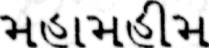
મહામહીમ
